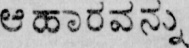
ಆಹಾರವನ್ನು
